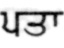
ਪਤਾ
